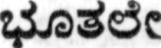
ಭೂತಲೇ
